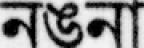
নঙনা
